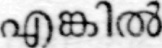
എങ്കില്‍
